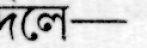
দিলে-
